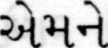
એમને
